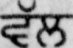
ਵੱਲ
